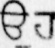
ਉਹ
